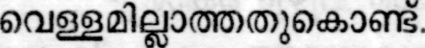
വെള്ളമില്ലാത്തതുകൊണ്ട്.
